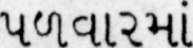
પળવારમાં
